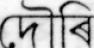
দৌৰি
